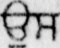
ਉਸ
